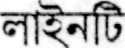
লাইনটি
